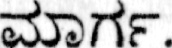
ಮಾರ್ಗ.
